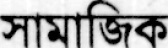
সামাজিক
